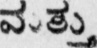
ಮತ್ತು
